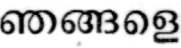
ഞങ്ങളെ
